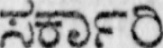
ಸರ್ಕಾರಿ
